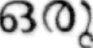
ഒരു
